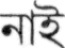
নাই
